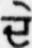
ਦੇ
